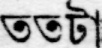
ততটা
